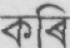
কৰি
